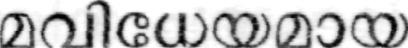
മവിധേയമായ
